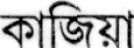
কাজিয়া
